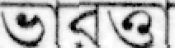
ভারত্তা
